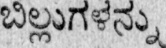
ಬಿಲ್ಲುಗಳನ್ನು
